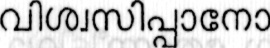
വിശ്വസിപ്പാനോ
